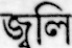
জ্বলি
